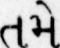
તમે
